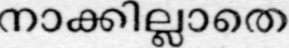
നാക്കില്ലാതെ
